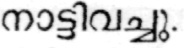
നാട്ടിവച്ചു.
